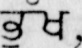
ਭੁੱਖ,
